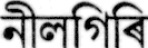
নীলগিৰি
